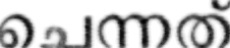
ചെന്നത്
